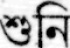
শুনি
